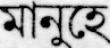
মানুহে
